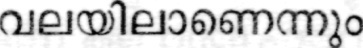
വലയിലാണെന്നും
